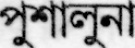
পুশালুনা
